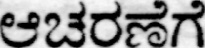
ಆಚರಣೆಗೆ
